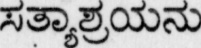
ಸತ್ಯಾಶ್ರಯನು
